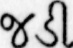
જડી
